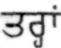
ਤਰ੍ਹਾਂ
